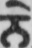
ਨੇ
